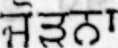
ਜੋੜਨਾ
